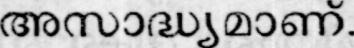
അസാദ്ധ്യമാണ്.
